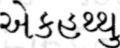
એકહથ્થુ
